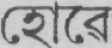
হোৱে
